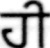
ਹੀ
